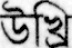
উখ্রি
